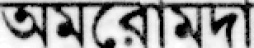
অমরোমদা
